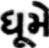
ધૂમે
